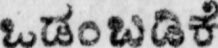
ಒಡಂಬಡಿಕೆ
